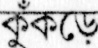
কুঁকড়ে
